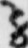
કે
